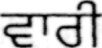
ਵਾਰੀ
